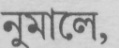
নুমালে,
